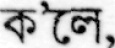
ক'লে,
